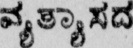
ವ್ಯತ್ಯಾಸದ
